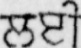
ਲਈ
